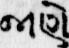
જાણે
